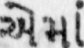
એમાં
